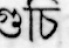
গুচি
